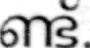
ണ്ട്.
